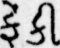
ફેંકી
